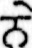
ਨੇ
